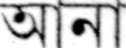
আনা
